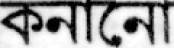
কনানো
